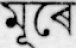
মূৰে
